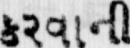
કરવાની
